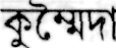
কুম্মৈদা
